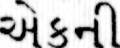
એકની
